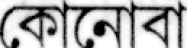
কোনোবা
